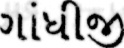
ગાંધીજી
